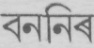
বননিৰ
